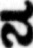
ನ
